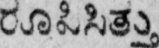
ರೂಪಿಸಿತ್ತು
